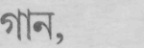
গান,
